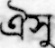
ঐসু
